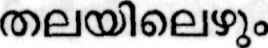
തലയിലെഴും
